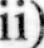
(ii)
